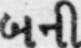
બની
